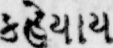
કહેયાય
